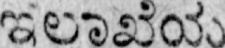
ಇಲಾಖೆಯ
